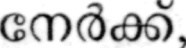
നേര്‍ക്ക്,
